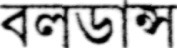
বলডান্স
